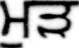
ਮੁੜ
